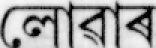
লোৱাৰ
